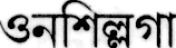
ওনশিল্লগা
